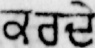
ਕਰਦੇ
